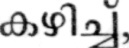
കഴിച്ച്,
